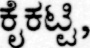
ಕೈಕಟ್ಟಿ,
